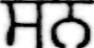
ਸਨ
